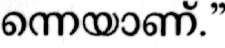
ന്നെയാണ്.”
